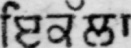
ਇਕੱਲਾ
